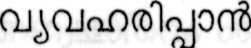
വ്യവഹരിപ്പാന്‍
